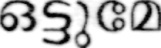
ഒട്ടുമേ
